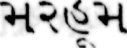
મરહૂમ
